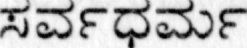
ಸರ್ವಧರ್ಮ
